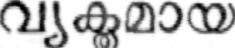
വ്യക്തമായ
